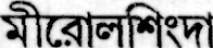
মীরোলশিংদা
